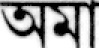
অমা
